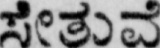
ಸೇತುವೆ
